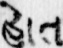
હોત
